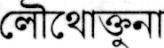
লৌথোক্তুনা
